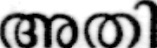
അതി
